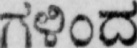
ಗಳಿಂದ
